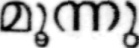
മൂന്നു
